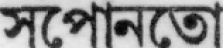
সপোনতো
